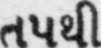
તપથી
